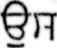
ਉਸ
